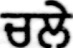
ਚਲੇ
